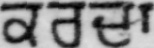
ਕਰਦਾ
